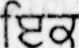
ਇਕ
